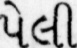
પેલી
